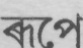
ৰূপে
